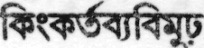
কিংকৰ্তব্যবিমুঢ়
